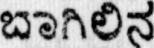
ಬಾಗಿಲಿನ
